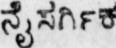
ನೈಸರ್ಗಿಕ
